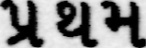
પ્રથમ
